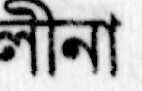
লীনা
